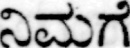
ನಿಮಗೆ
